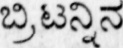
ಬ್ರಿಟನ್ನಿನ
